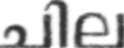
ചില
